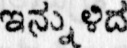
ಇನ್ನುಳಿದ
